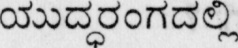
ಯುದ್ಧರಂಗದಲ್ಲಿ
